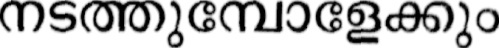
നടത്തുമ്പോളേക്കും
